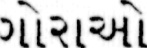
ગોરાઓ
